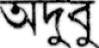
অদুবু
